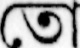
তো
